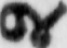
જ
